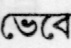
ভেবে
